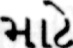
માટે
